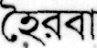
হৈরবা
